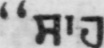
''ਸਾਹ
